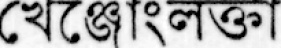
খেঞ্জোংলক্তা
